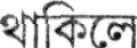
থাকিলে
